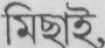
মিছাই,
